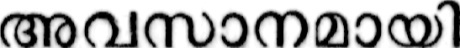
അവസാനമായി
